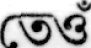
তেওঁ
